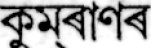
কুম্‌ৰাণৰ
